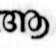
ആ
